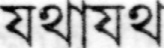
যথাযথ
